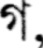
গ,
